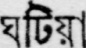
ঘটিয়া
